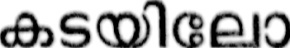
കടയിലോ
